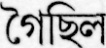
গৈছিল
